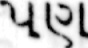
પણ
